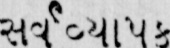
સર્વવ્યાપક
